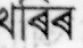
খৰিৰ
